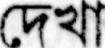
দেখা
